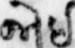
જોઈ
